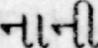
નાની
